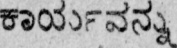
ಕಾರ್ಯವನ್ನು
